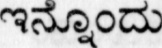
ಇನ್ನೊಂದು
